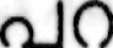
പറ
